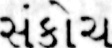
સંકોચ
